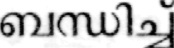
ബന്ധിച്ച്
